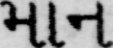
માન
